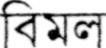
বিমল
